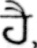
ਹੈ,
